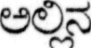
ಅಲ್ಲಿನ
